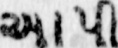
આપી
